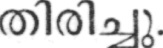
തിരിച്ചു.
